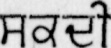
ਸਕਦੀ
